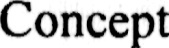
Concept
